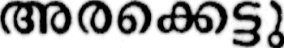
അരക്കെട്ടു
